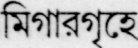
মিগারগৃহে
